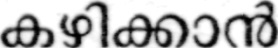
കഴിക്കാന്‍
